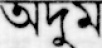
অদুম
